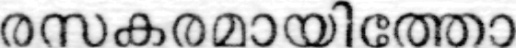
രസകരമായിത്തോ
